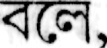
বলে,
